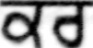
ਕਰ
